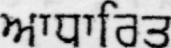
ਆਧਾਰਿਤ
